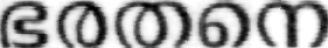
ഭരതനെ
